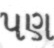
પણ
